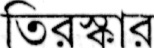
তিরস্কার
